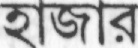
হাজার
